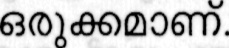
ഒരുക്കമാണ്.
